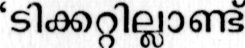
‘ടിക്കറ്റില്ലാണ്ട്
